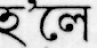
হ'লে
